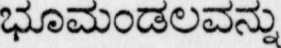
ಭೂಮಂಡಲವನ್ನು
